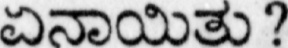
ಏನಾಯಿತು?
